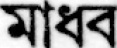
মাধব
